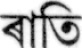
ৰাতি
